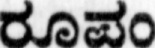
ರೂಪಂ
